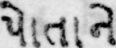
પોતાને
